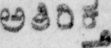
ಅತಿರಿಕ್ತ
